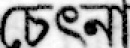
চেৎনা
